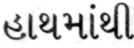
હાથમાંથી
